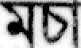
মচা
